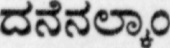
ದನೆನಲ್ಕಾಂ
